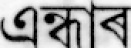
এন্ধাৰ
